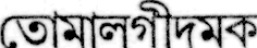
তোমালগীদমক
